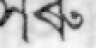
সৰু
